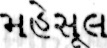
મહેસૂલ
